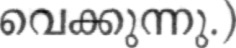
വെക്കുന്നു.)
